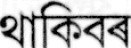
থাকিবৰ
